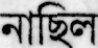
নাছিল
